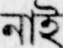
নাই
